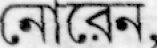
নোরেন,
